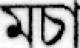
মচা
